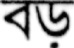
বড়
